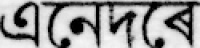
এনেদৰে
